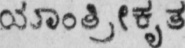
ಯಾಂತ್ರೀಕೃತ
